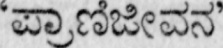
‘ಪ್ರಾಣಿಜೀವನ’
